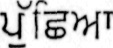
ਪੁੱਛਿਆ
